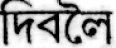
দিবলৈ
